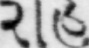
રાહ
